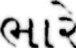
ભારે
